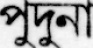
পুদুনা
